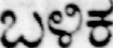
ಬಳಿಕ
